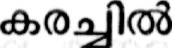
കരച്ചില്‍
